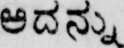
ಅದನ್ನು
